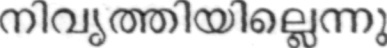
നിവ്യത്തിയില്ലെന്നു
